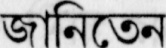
জানিতেন
